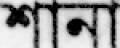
শানা
